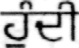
ਹੁੰਦੀ
